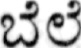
ಬೆಲೆ
